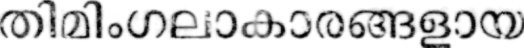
തിമിംഗലാകാരങ്ങളായ
